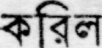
করিল
